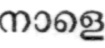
നാളെ
